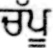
ਚੱਪੂ
